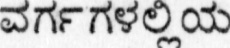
ವರ್ಗಗಳಲ್ಲಿಯ
